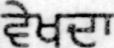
ਵੇਖਦਾ
